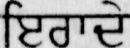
ਇਰਾਦੇ
